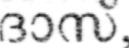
ദാസ്,
